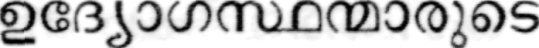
ഉദ്യോഗസ്ഥന്മാരുടെ
